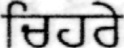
ਚਿਹਰੇ
